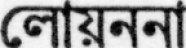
লোয়ননা
